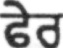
ਫੇਰ
